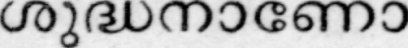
ശുദ്ധനാണോ
